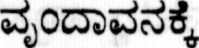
ವೃಂದಾವನಕ್ಕೆ
